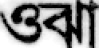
ওঝা
